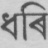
ধৰি
